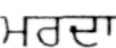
ਮਰਦਾ
